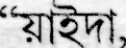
“য়াইদা,
